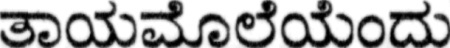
ತಾಯಮೊಲೆಯೆಂದು
